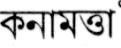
কনামত্তা
